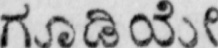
ಗೂಡಿಯೇ
